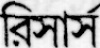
রিসার্স
